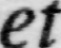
et
